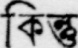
কিন্তু
